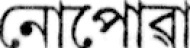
নোপোৱা
